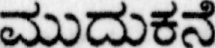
ಮುದುಕನೆ
